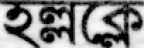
হল্লক্লে
